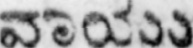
ವಾಯು
